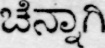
ಚೆನ್ನಾಗಿ
